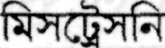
মিসট্রেসনি
